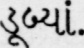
ડૂબ્યાં.
